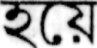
হয়ে
